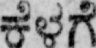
ಕೆಳಗೆ
